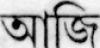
আজি
